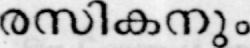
രസികനും
